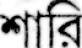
শারি
